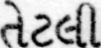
તેટલી
